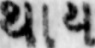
થાય
